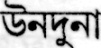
উনদুনা
